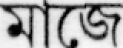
মাজে
